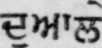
ਦੁਆਲੇ
